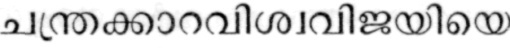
ചന്ത്രക്കാറവിശ്വവിജയിയെ
